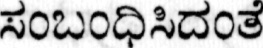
ಸಂಬಂಧಿಸಿದಂತೆ
